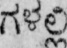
ಗಳಲ್ಲಿ
